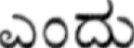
ಎಂದು
